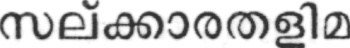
സല്ക്കാരതളിമ
